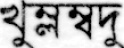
খুম্লম্বদু
